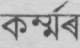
কৰ্ম্মৰ
